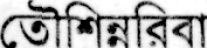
তৌশিন্নরিবা
